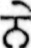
ਨੇ
